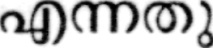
എന്നതു
